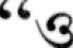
“ও
